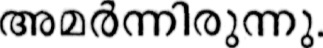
അമര്‍ന്നിരുന്നു.
